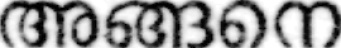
അങ്ങനെ
